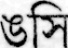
ঙসি
